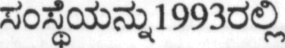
ಸಂಸ್ಥೆಯನ್ನು1993ರಲ್ಲಿ
